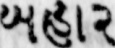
બહાર
